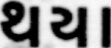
થયા
